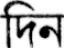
দিন
